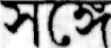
সঙ্গে
